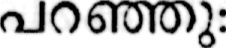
പറഞ്ഞു:
